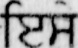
ਇਸੇ
